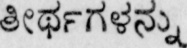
ತೀರ್ಥಗಳನ್ನು
